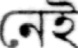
নেই
